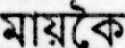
মায়কৈ
